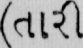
(તારી
